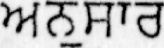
ਅਨੁਸਾਰ
